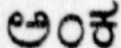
ಅಂಕ
